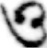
ও
